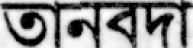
তানবদা
